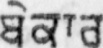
ਬੇਕਾਰ
